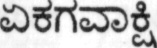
ಏಕಗವಾಕ್ಷಿ
